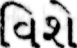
વિશે
